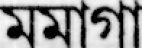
মমাগা
